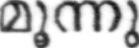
മൂന്നു
